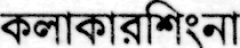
কলাকারশিংনা
